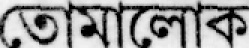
তোমালোক
